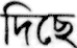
দিছে
